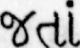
જતાં
